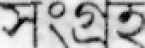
সংগ্ৰত
